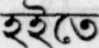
হইতে
